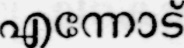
എന്നോട്
